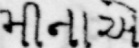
મીનાએ
